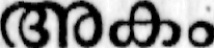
അകം
